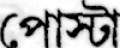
পোসক্টা
